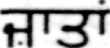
ਜ਼ਾਤਾਂ
